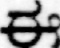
ಈ
